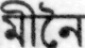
মীনৈ
